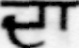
ਦਾ
